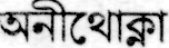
অনীথোক্না
